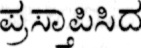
ಪ್ರಸ್ತಾಪಿಸಿದ
